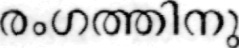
രംഗത്തിനു
